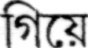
গিয়ে
